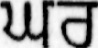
ਘਰ
